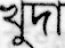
খুদা
